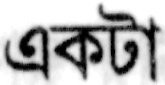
একটা
